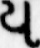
ય
